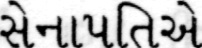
સેનાપતિએ
